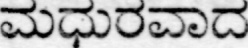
ಮಧುರವಾದ
